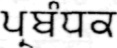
ਪ੍ਰਬੰਧਕ
